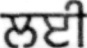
ਲਈ
